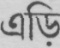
এড়ি
